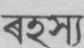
ৰহস্য
